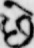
છે
